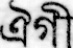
ঐগী
